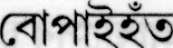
বোপাইহঁত
